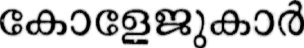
കോളേജുകാര്‍
